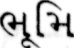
ભૂમિ
